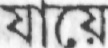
যায়ে
